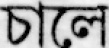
চালে
